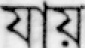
যায়
